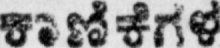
ಕಾಣಿಕೆಗಳ
